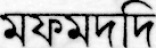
মফমদদি
